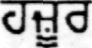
ਹਜ਼ੂਰ
